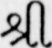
શ્રી
